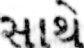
સાથે
